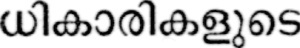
ധികാരികളുടെ
